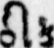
ઠીક
